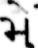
મેં
